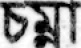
চম্না
